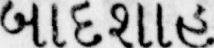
બાદશાહ
